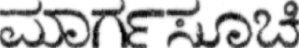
ಮಾರ್ಗಸೂಚಿ
